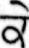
ਕੇ
